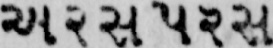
અરસપરસ
